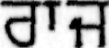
ਰਾਜ
